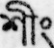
শীং
